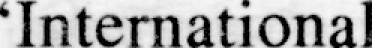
‘Internatinal
